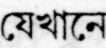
যেখানে
